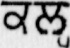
ਕਲ੍ਹ
